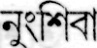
নুংশিবা
